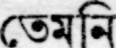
তেমনি
